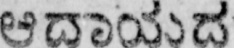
ಆದಾಯದ
